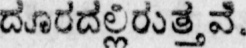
ದೂರದಲ್ಲಿರುತ್ತವೆ.
